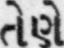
તેણે
